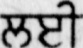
ਲਈ
